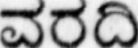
ವರದಿ
